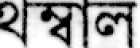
থম্বাল
